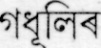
গধূলিৰ
